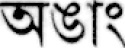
অঙাং
